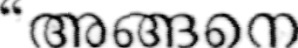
"അങ്ങനെ
